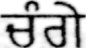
ਚੰਗੇ
